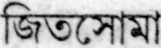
জিতসোমা
